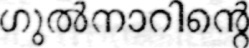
ഗുല്‍നാറിന്റെ
